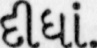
દીઘાં.
